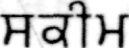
ਸਕੀਮ
